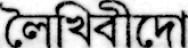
লৈখিবীদো
